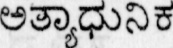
ಅತ್ಯಾಧುನಿಕ
